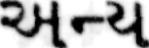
અન્ય
